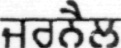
ਜਰਨੈਲ
